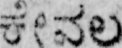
ಕೇವಲ
